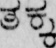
ತಕ್ಕ
